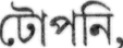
টোপনি,
